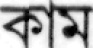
কাম
